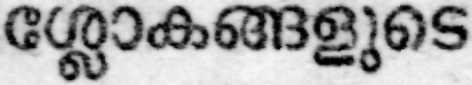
ശ്ളോകങ്ങളുടെ
